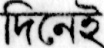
দিনেই
